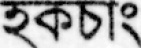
হকচাং
